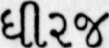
ધીરજ
